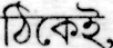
ঠিকেই,
